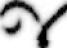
જ
